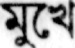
মুখে
